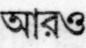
আরও
